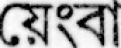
য়েংবা
